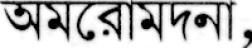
অমরোমদনা,
